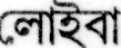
লোইবা
